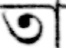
তা
